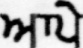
ਆਪੇ
